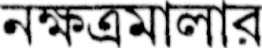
নক্ষত্রমালার
